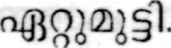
ഏറ്റുമുട്ടി.
